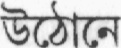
উঠোনে
